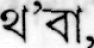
থ'বা,
